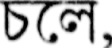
চলে,
